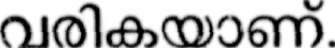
വരികയാണ്.
